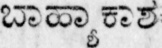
ಬಾಹ್ಯಾಕಾಶ
